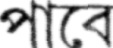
পাবে
